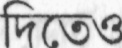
দিতেও
